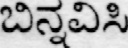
ಬಿನ್ನವಿಸಿ
